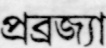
প্রব্রজ্যা
